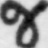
જ
